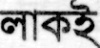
লাকই
